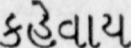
કહેવાય
